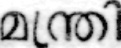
മന്ത്രി
